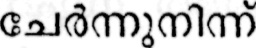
ചേര്‍ന്നുനിന്ന്
